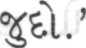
જુદો.'
